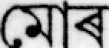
মোৰ
